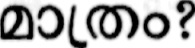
മാത്രം?
